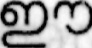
ഈ
